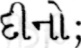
દીનો;
